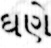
ઘણે
